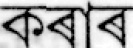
কৰাৰ
